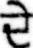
ਦੇ
